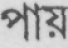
পায়
